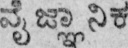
ವೈಜ್ಞಾನಿಕ
